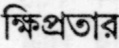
ক্ষিপ্রতার
